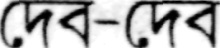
দেব-দেব
